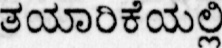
ತಯಾರಿಕೆಯಲ್ಲಿ
